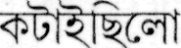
কটাইছিলো
